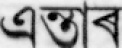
এন্তাৰ
